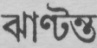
ঝাণ্টন্ত
